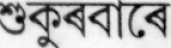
শুকুৰবাৰে
